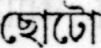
ছোটো
